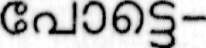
പോട്ടെ-
